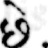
છે.
